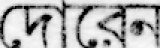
দোরেন
